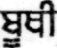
ਬੂਥੀ
